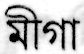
মীগা
